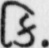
કિ.
